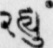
રહ્યું
